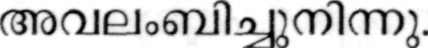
അവലംബിച്ചുനിന്നു.
